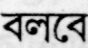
বলবে
